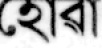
হোৱা
